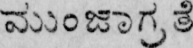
ಮುಂಜಾಗ್ರತೆ
